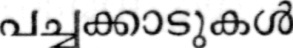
പച്ചക്കാടുകള്‍
